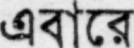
এবারে
